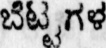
ಬೆಟ್ಟಗಳ
